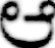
ಆ
